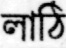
লাঠি
